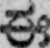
ಈ
